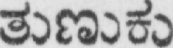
ತುಣುಕು
